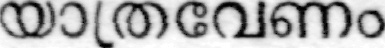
യാത്രവേണം
